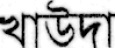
খাউদা
